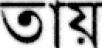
তায়
